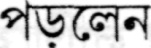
পড়লেন
